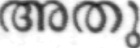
അതു
